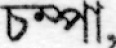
চম্পা,
